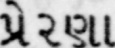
પ્રેરણા
